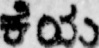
ಕೆಯ
